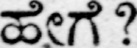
ಹೇಗೆ?
